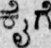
ಕೈಗೆ
